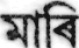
মাৰি
